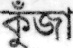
কুঁজা
